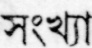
সংখ্যা
